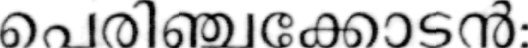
പെരിഞ്ചക്കോടന്‍:
